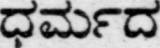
ಧರ್ಮದ
